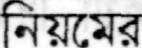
নিয়মের
